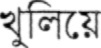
খুলিয়ে
